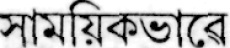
সাময়িকভাৱে
